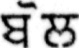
ਬੋਲ
